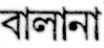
বালানা
